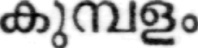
കുമ്പളം
